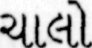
ચાલો
